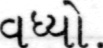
વધ્યો.
